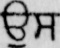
ਉਸ
